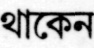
থাকেন
